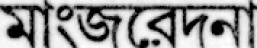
মাংজরেদনা
